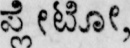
ಪ್ಲೇಟೋ,
